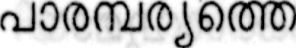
പാരമ്പര്യത്തെ
